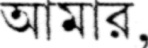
আমার,
